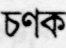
চণক
